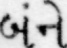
બંને
